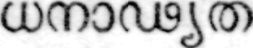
ധനാഢ്യത
